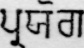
ਪ੍ਰਯੋਗ
